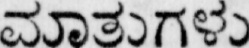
ಮಾತುಗಳು
